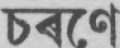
চৰণে
